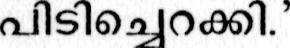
പിടിച്ചെറക്കി.’
